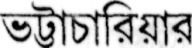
ভট্টাচারিয়ার
